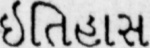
ઇતિહાસ
